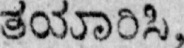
ತಯಾರಿಸಿ,
